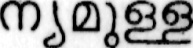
ന്യമുള്ള
